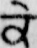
ਕੇ
